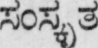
ಸಂಸ್ಕೃತ
